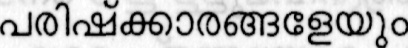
പരിഷ്ക്കാരങ്ങളേയും
